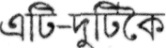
এটি-দুটিকৈ
